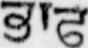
ਭਾਫ
